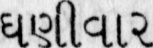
ઘણીવાર
